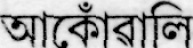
আকোঁৱালি
